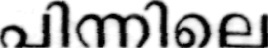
പിന്നിലെ
